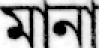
মানা
